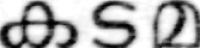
കടമ
